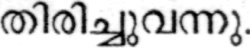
തിരിച്ചുവന്നു.
